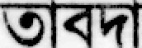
তাবদা
